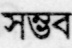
সম্ভব
